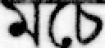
মচে
